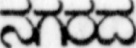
ನಗರದ
